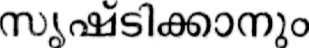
സൃഷ്ടിക്കാനും
